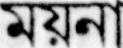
ময়না
